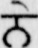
ਨੇ
